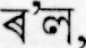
ৰ'ল,
